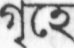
গৃহে
